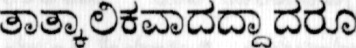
ತಾತ್ಕಾಲಿಕವಾದದ್ದಾದರೂ
